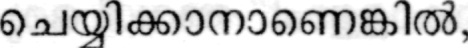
ചെയ്യിക്കാനാണെങ്കില്‍,
